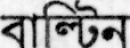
বাল্টিন
